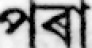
পৰা
